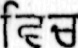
ਵਿਚ
